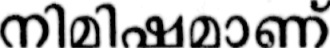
നിമിഷമാണ്
